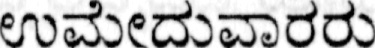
ಉಮೇದುವಾರರು
